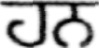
ਹਨ
